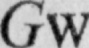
Gw
